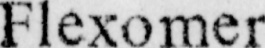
Flexomer
